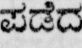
ಪಡೆದ
